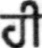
ਹੀ
